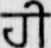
ਹੀ
